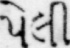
પેલી
